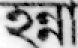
হন্না
